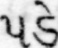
પડે
